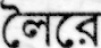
লৈরে
